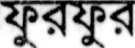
ফুরফুর
